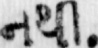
નથી.
